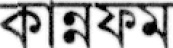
কান্নফম
